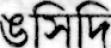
ঙসিদি
